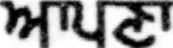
ਆਪਣਾ
